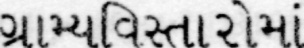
ગ્રામ્યવિસ્તારોમાં
